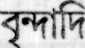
বৃন্দাদি
